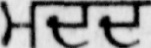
ਮਦਦ
